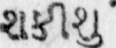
શકીશું
